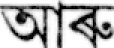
আৰু
